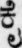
ಕೈ
